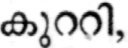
കുററി,
